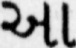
આ
